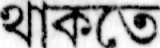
থাকতে
